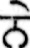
ਨੇ
